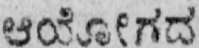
ಆಯೋಗದ
